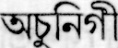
অচুনিগী
